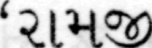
'રામજી
